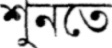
শুনতে
